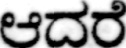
ಆದರೆ
